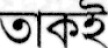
তাকই
